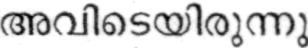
അവിടെയിരുന്നു.
